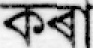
কৰা
